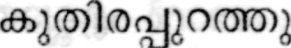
കുതിരപ്പുറത്തു
